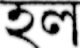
হল
